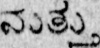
ಮತ್ತು
